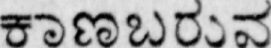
ಕಾಣಬರುವ
